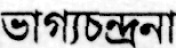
ভাগ্যচন্দ্রনা
